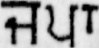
ਜਪਾ
